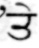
'ਤੇ
